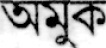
অমুক
